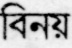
বিনয়
